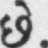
છે.
